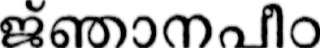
ജ്ഞാനപീഠ
